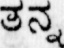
ತನ್ನ
